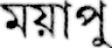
ময়াপু
